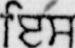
ਇਸ
